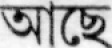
আছে
